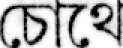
চোথে
